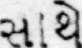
સાથે
